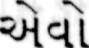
એવો
